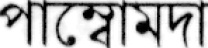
পাম্বোমদা
